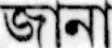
জানা
